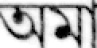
অমা
